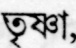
তৃষ্ণা,
